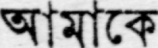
আমাকে
